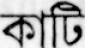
কাটি
